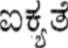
ಐಕ್ಯತೆ
